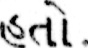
હતો.
